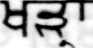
ਖੜ੍ਰਾ
